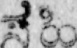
ಸಹಿ
